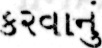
કરવાનું
